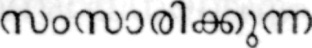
സംസാരിക്കുന്ന
